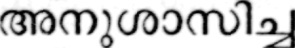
അനുശാസിച്ച
